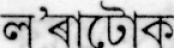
ল'ৰাটোক
